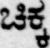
ಚಿಕ್ಕ
